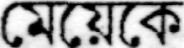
মেয়েকে
